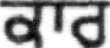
ਕਾਰ
